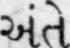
અંતે
